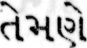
તેમણે
